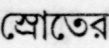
স্রোতের
